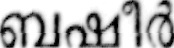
ബഷീര്‍
